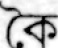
কৈ
